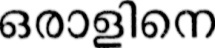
ഒരാളിനെ
